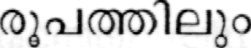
രൂപത്തിലും
